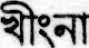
খীংনা
